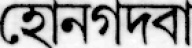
হোনগদবা
